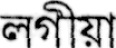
লগীয়া
